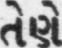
તેણે
